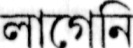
লাগেনি
